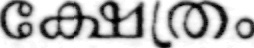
ക്ഷേത്രം
